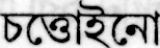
চত্তোইনো
